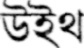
উইথ
